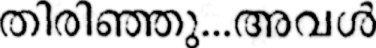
തിരിഞ്ഞു...അവള്‍
